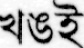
খঙই
